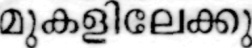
മുകളിലേക്കു
